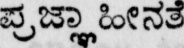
ಪ್ರಜ್ಞಾಹೀನತೆ
